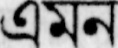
এমন
